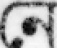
নে
